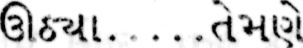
ઊઠ્યા.....તેમણે
